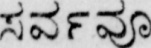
ಸರ್ವವೂ
